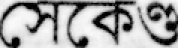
সেকেণ্ড
